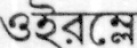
ওইরম্লে
